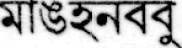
মাঙহনববু
